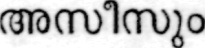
അസീസും
